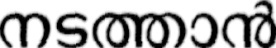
നടത്താന്‍
